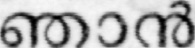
ഞാന്‍
